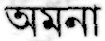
অমনা
